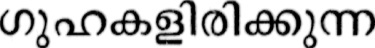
ഗുഹകളിരിക്കുന്ന
